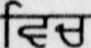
ਵਿਚ
